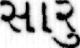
સારુ
